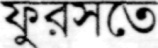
ফুরসতে
